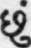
છું
